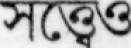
সত্ত্বেও
